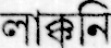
লাক্কনি
